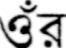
ওঁর
